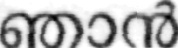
ഞാന്‍
